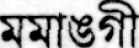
মমাঙগী
